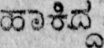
ಹಾಕಿದ್ದ
